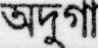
অদুগা
